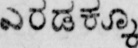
ಎರಡಕ್ಕೂ
